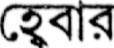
হে্বার
